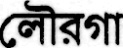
লৌরগা
